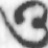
ও
